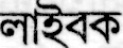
লাইবক
